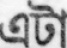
এটা
